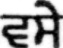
ਵਸੇ
